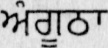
ਅੰਗੂਠਾ
